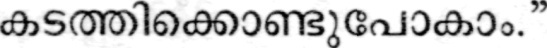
കടത്തിക്കൊണ്ടുപോകാം."
